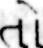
તો
